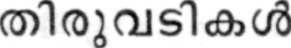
തിരുവടികള്‍
